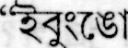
“ইবুংঙো
